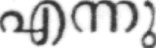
എന്നു
